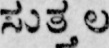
ಸುತ್ತಲ
